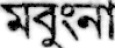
মবুংনা
